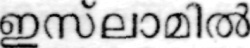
ഇസ്ലാമില്‍
